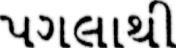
પગલાથી
